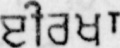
ਈਰਖਾ
